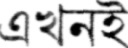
এখনই
